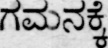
ಗಮನಕ್ಕೆ
